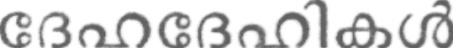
ദേഹദേഹികള്‍
